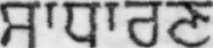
ਸਾਧਾਰਣ
